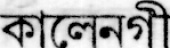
কালেনগী
